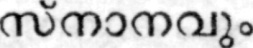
സ്നാനവും
